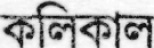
কলিকাল
